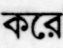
করে
